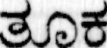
ತೂಕ
